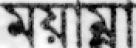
ময়াম্না
